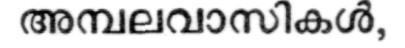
അമ്പലവാസികള്‍,
